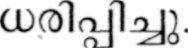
ധരിപ്പിച്ചു.
